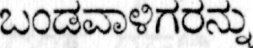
ಬಂಡವಾಳಿಗರನ್ನು
